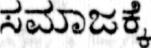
ಸಮಾಜಕ್ಕೆ
